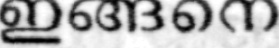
ഇങ്ങനെ
